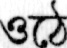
ওঠে
